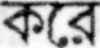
করে
